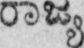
ರಾಜ್ಯ
